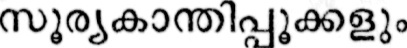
സൂര്യകാന്തിപ്പൂക്കളും
